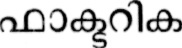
ഫാക്ടറിക
